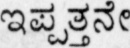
ಇಪ್ಪತ್ತನೇ
